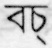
বচ্
